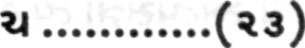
ચ............(૨૩)
